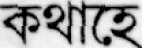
কথাহে
